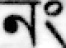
নং
